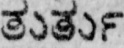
ತುರ್ತು
